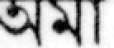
অমা
